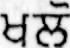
ਖਲੋ
